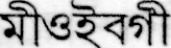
মীওবগী
